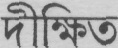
দীক্ষিত
